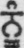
ਨੂੰ
